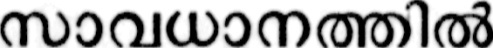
സാവധാനത്തില്‍
